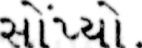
સોંપ્યો.
